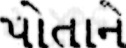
પોતાને
